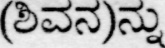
(ಶಿವನ)ನ್ನು
